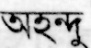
অহন্দু
